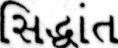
સિદ્ધાંત
